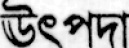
ঊৎপদা
